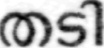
തടി
